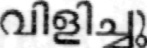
വിളിച്ചു
